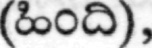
(ಹಿಂದಿ),
